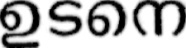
ഉടനെ
